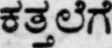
ಕತ್ತಲೆಗೆ
